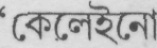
'কেলেইনো
